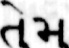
તેમ
